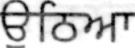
ਉਠਿਆ
